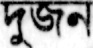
দুজন
